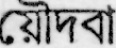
য়ৌদবা
